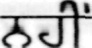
ਨਹੀਂ
